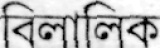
বিলালিক
